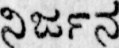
ನಿರ್ಜನ
